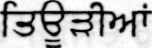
ਤਿਊੜੀਆਂ
